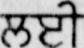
ਲਈ
